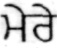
ਮੇਰੇ
